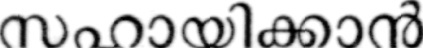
സഹായിക്കാന്‍
